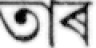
তাৰ
